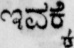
ಇವಕ್ಕೆ
